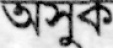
অসুক
